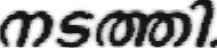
നടത്തി.
